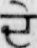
ਦੇ
